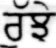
ਰੁੱਝੇ
